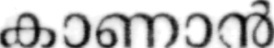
കാണാന്‍
